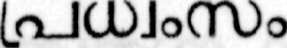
പ്രധ്വംസം
